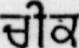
ਚੀਕ
